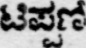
ಟಿಪ್ಪಣಿ
